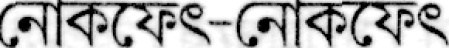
নোকফেৎ-নোকফেৎ
